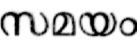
സമയം
